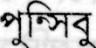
পুন্সিবু
